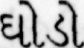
ઘોડો
